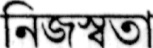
নিজস্বতা
